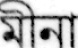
মীনা
